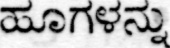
ಹೂಗಳನ್ನು
